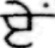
ਏਂ
